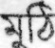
মুঠি
